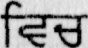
ਵਿਚ
